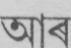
আৰ
